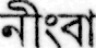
নীংবা
